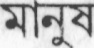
মানুষ
